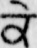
ਕੇ
